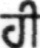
ਹੀ
